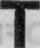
T
